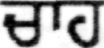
ਚਾਹ
